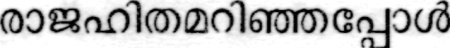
രാജഹിതമറിഞ്ഞപ്പോള്‍
